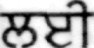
ਲਈ
